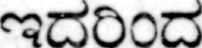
ಇದರಿಂದ
